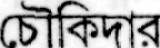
চৌকিদার
